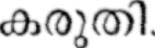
കരുതി.
